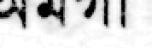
অমগা
